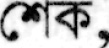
শেক,
